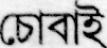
চোবাই
